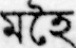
মহৈ
